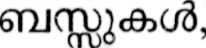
ബസ്സുകള്‍,
